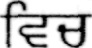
ਵਿਚ
